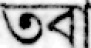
তবা
